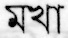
মখা
